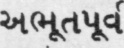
અભૂતપૂર્વ
